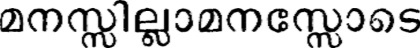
മനസ്സില്ലാമനസ്സോടെ
